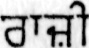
ਰਾਜ਼ੀ
